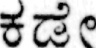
ಕಡೇ
